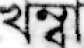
খম্বা
